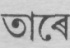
তাৰে
